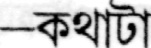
-কথাটা
